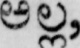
ಅಲ್ಲ,
